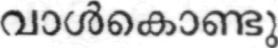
വാള്‍കൊണ്ടു
